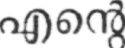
എന്റെ
